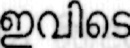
ഇവിടെ
